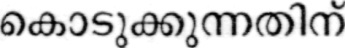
കൊടുക്കുന്നതിന്
